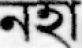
নহা
